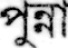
পুন্না
